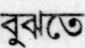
বুঝতে
